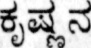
ಕೃಷ್ಣನ
